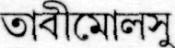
তাবীমোলসু
